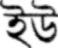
ইউ
